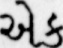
એક
